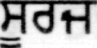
ਸੂਰਜ
